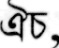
ঐচ,
